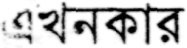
এখনকার
